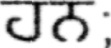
ਹਨ;
